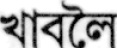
খাবলৈ
